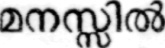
മനസ്സില്‍
